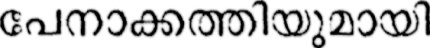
പേനാക്കത്തിയുമായി
